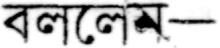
বললেন–
